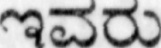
ಇವರು
